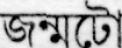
জন্মটো
